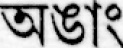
অঙাং
